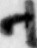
ન
